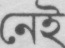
নেই
